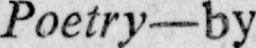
Poetry-by
